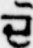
ਦੋ
